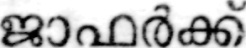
ജാഫര്‍ക്ക്
